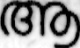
ആ
